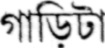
গাড়িটা
